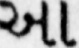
આ
